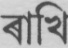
ৰাখি
